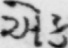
એક
